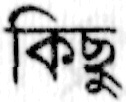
কিছু
